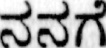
ನನಗೆ
